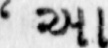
આ
